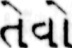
તેવો
